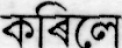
কৰিলে
